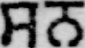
ਸਨ
